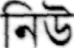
নিউ
